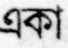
একা
